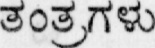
ತಂತ್ರಗಳು
